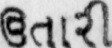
ઉતારી
